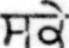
ਸਕੇ
